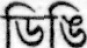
ডিঙি
